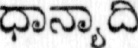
ಧಾನ್ಯಾದಿ
